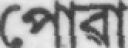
পোৱা
